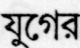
যুগের
